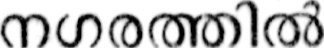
നഗരത്തില്‍
